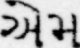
એમ
